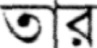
তার
